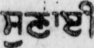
ਸੁਣਾਈ
